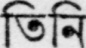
তিনি
